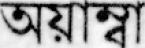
অয়াম্বা
